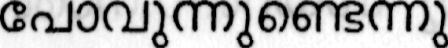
പോവുന്നുണ്ടെന്നു
